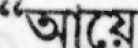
"আয়ে
